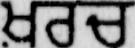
ਖ਼ਰਚ
